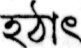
হঠাৎ
